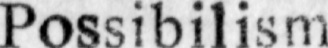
Possibilism
